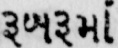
રૂબરૂમાં
